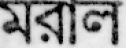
মরাল
